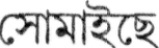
সোমাইছে
